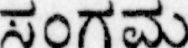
ಸಂಗಮ
